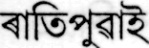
ৰাতিপুৱাই
